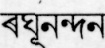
ৰঘূনন্দন
